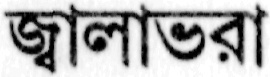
জ্বালাভরা
